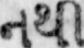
નથી
